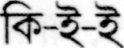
কি-ই-ই
